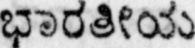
ಭಾರತೀಯ
